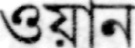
ওয়ান
